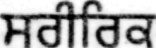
ਸਰੀਰਿਕ
